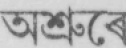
অশ্ৰুৰে
